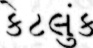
કેટલુંક
